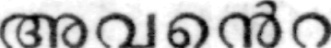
അവന്റെ
